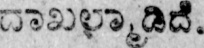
ದಾಖಲ್ಮಾಡಿದೆ.
